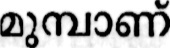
മുമ്പാണ്
